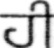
ਹੀ
